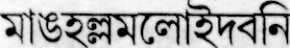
মাঙহল্লমলোইদবনি
